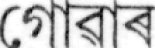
গোৱাৰ
